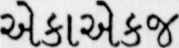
એકાએકજ
